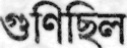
গুণিছিল
